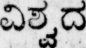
ವಿಶ್ವದ
